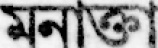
মনাক্তা
